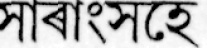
সাৰাংসহে
